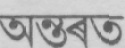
অন্তৰত
